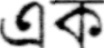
এক
